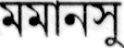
মমানসু
